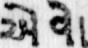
એવો
